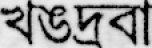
খঙদ্রবা
